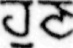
ਹੁਣ
